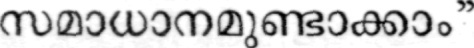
സമാധാനമുണ്ടാക്കാം”
